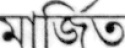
মার্জিত
